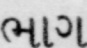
ભાગ
